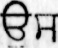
ਉਸ
